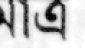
মাএ
